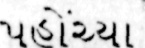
પહોંચ્યા
